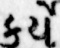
કર્યે
